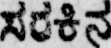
ಸರಕಿನ
